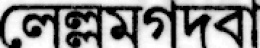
লেল্লমগদবা
